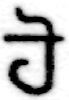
ਹੋ
